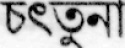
চৎতুনা
